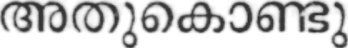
അതുകൊണ്ടു
